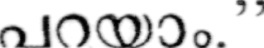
പറയാം."
